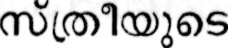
സ്ത്രീയുടെ
